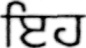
ਇਹ
